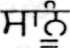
ਸਾਨੂੰ
